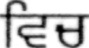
ਵਿਚ
